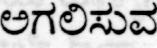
ಅಗಲಿಸುವ
